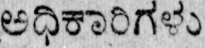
ಅಧಿಕಾರಿಗಳು
